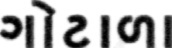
ગોટાળા
